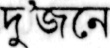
দু'জনে
